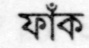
ফাঁক
